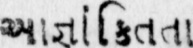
આજ્ઞાકિતતા
